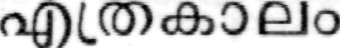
എത്രകാലം
